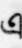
এ
